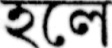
হলে
